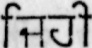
ਜਿਹੀ
